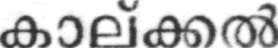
കാല്ക്കല്‍
